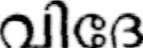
വിദേ
